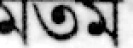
মতম
